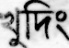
খুদিং
